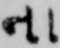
ના
